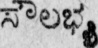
ಸೌಲಭ್ಯ
